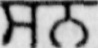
ਸਨ
